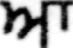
ਆ
